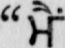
''ਮੈਂ
